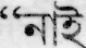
"নাই
